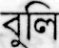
বুলি
